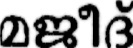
മജീദ്
